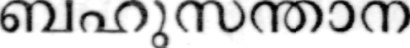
ബഹുസന്താന
